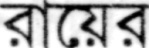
রায়ের
